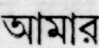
আমার
